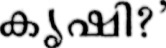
കൃഷി?’
